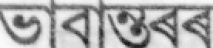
ভাবান্তৰৰ
